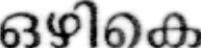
ഒഴികെ
